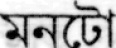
মনটো
